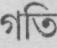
গতি
